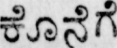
ಕೊನೆಗೆ
